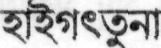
হাইগৎতুনা
